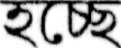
হচ্ছে
